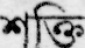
শক্তি
